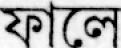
ফালে
